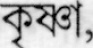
কৃষ্ণা,
